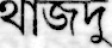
থাজদু
